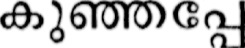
കുഞ്ഞപ്പേ
